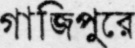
গাজিপুরে
